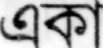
একা
